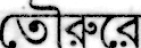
তৌরুরে
